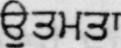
ਉਤਮਤਾ
